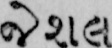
જેશલ
